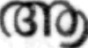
ആ
